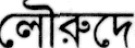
লৌরুদে
